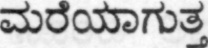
ಮರೆಯಾಗುತ್ತ
